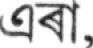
এৰা,
